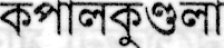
কপালকুণ্ডলা
